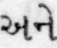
અને
